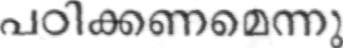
പഠിക്കണമെന്നു
